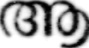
ആ
